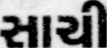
સાચી
